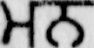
ਮਨ
